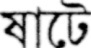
ষাটে
